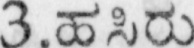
3.ಹಸಿರು
